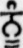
ਨੂੰ
